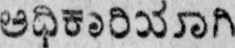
ಅಧಿಕಾರಿಯಾಗಿ
